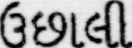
ઉછાલી
